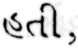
હતી,
